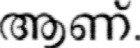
ആണ്.
